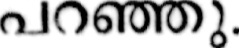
പറഞ്ഞു.
